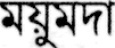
ময়ুমদা
